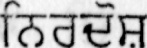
ਨਿਰਦੋਸ਼
